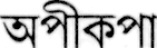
অপীকপা
